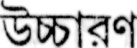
উচ্চারণ
